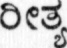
ರೀತ್ಯ
